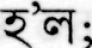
হ'ল;
